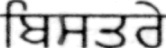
ਬਿਸਤਰੇ
